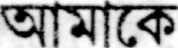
আমাকে
